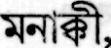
মনাক্কী,
